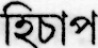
হিচাপ
